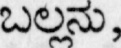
ಬಲ್ಲನು,
